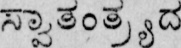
ಸ್ವಾತಂತ್ರ್ಯದ
